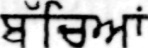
ਬੱਚਿਆਂ
